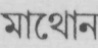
মাথোন
